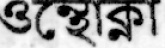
ওন্থোক্না
